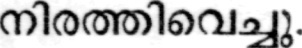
നിരത്തിവെച്ചു.
